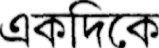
একদিকে
